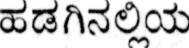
ಹಡಗಿನಲ್ಲಿಯ
